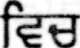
ਵਿਚ
